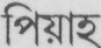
পিয়াহ
